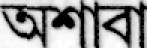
অশাবা
